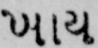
ખાય
